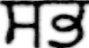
ਸਭ
